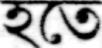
হতে
